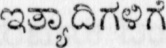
ಇತ್ಯಾದಿಗಳಿಗೆ
